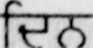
ਦਿਨ
